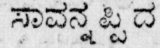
ಸಾವನ್ನಪ್ಪಿದ
